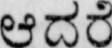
ಆದರೆ
